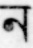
ন
